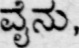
ವೈನು,
